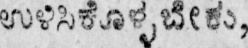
ಉಳಿಸಿಕೊಳ್ಳಬೇಕು,
